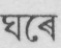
ঘৰে
